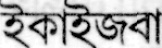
ইকাইজবা
